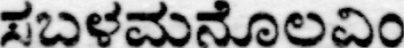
ಸಬಳಮನೊಲವಿಂ
